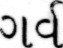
ગર્વ
